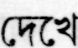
দেখে
